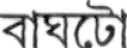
বাঘটো
